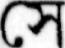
সে
